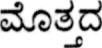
ಮೊತ್ತದ
